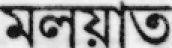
মলয়াত
